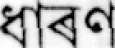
ধাৰণ
